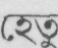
হেতু
